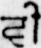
ਵੀ
